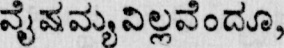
ವೈಷಮ್ಯವಿಲ್ಲವೆಂದೂ,
